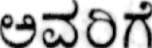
ಅವರಿಗೆ
